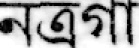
নত্রগা
